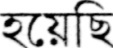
হয়েছি
